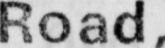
Road,
